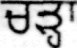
ਚੜ੍ਹਾ
